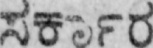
ಸರ್ಕಾರ
